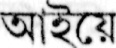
আইয়ে
